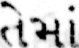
તેમાં
